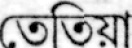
তেতিয়া
